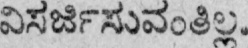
ವಿಸರ್ಜಿಸುವಂತಿಲ್ಲ.
